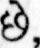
છે,
